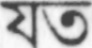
যত
